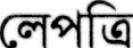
লেপত্রি
